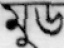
মুড
